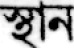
স্থান
